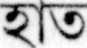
হাত
